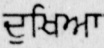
ਦੁਖਿਆ
